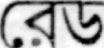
রেড
